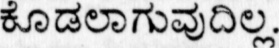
ಕೊಡಲಾಗುವುದಿಲ್ಲ.
